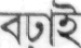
বঢ়াই
